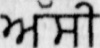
ਅੱਸੀ
